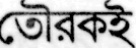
তৌরকই
